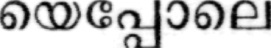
യെപ്പോലെ
